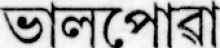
ভালপোৱা
